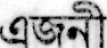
এজনী
